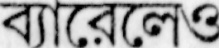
ব্যারেলেও
